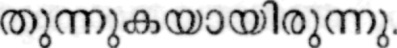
തുന്നുകയായിരുന്നു.
